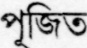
পূজিত
